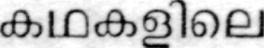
കഥകളിലെ
